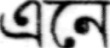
এনে
